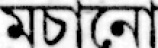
মচানো
